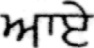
ਆਏ
